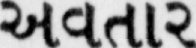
અવતાર
